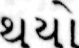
થયો
